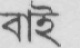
বাই
